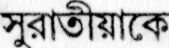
সুরাতীয়াকে
